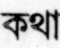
কথা
